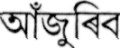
আঁজুৰিব
